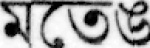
মতেঙ
